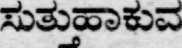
ಸುತ್ತುಹಾಕುವ
